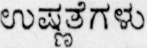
ಉಷ್ಣತೆಗಳು
